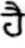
ਹੈ
